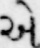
એ
